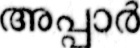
അപ്പാര്‍
